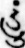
હું
